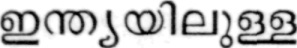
ഇന്ത്യയിലുള്ള
